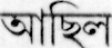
আছিল
